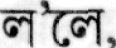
ল'লে,
